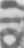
ਕੇ
